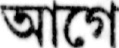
আগে
